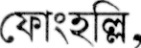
ফোংহল্লি,
